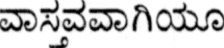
ವಾಸ್ತವವಾಗಿಯೂ
